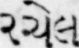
રચેલ
